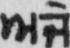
ਅਜੇ
